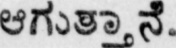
ಆಗುತ್ತಾನೆ.
